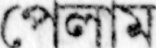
পেলাম
